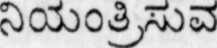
ನಿಯಂತ್ರಿಸುವ
